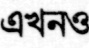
এখনও
